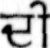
ਦੀ
